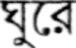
ঘুরে
